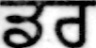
ਡਰ
